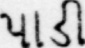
પાડી
